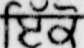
ਇੱਕੋ
